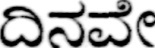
ದಿನವೇ
